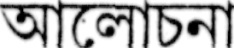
আলোচনা
